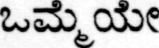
ಒಮ್ಮೆಯೇ
